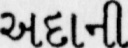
અદાની
